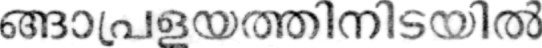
ങ്ങാപ്രളയത്തിനിടയില്‍
